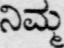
ನಿಮ್ಮ
